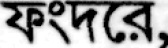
ফংদরে,
